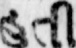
હતી
